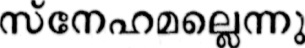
സ്നേഹമല്ലെന്നു
